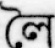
লৈ
